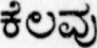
ಕೆಲವು
